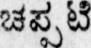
ಚಪ್ಪಟೆ
